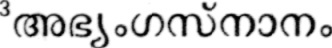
3അഭ്യംഗസ്നാനം
